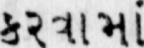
કરવામાં
